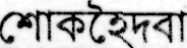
শোকহৈদবা
